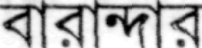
বারান্দার
